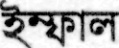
ইম্ফাল
